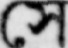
সে
